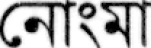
নোংমা
